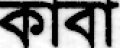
কাবা
